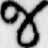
જ
